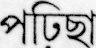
পঢ়িছা
